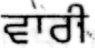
ਵਾਰੀ
